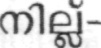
നില്ല്-
